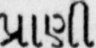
પ્રાણી
